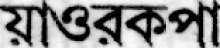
য়াওরকপা
